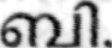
ബി.
